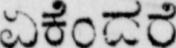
ಏಕೆಂದರೆ
